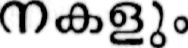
നകളും
